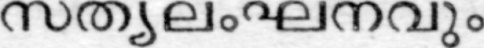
സത്യലംഘനവും
